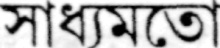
সাধ্যমতো
